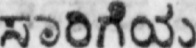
ಸಾರಿಗೆಯ
